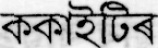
ককাইটিৰ
